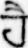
ਹੈ
